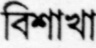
বিশাখা
